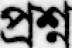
প্রশ্ন
